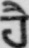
ਹੈ
